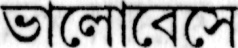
ভালোবেসে
